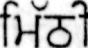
ਮਿੱਠੀ
